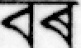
বৰ
